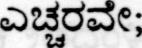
ಎಚ್ಚರವೇ;
